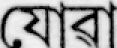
যোৱা
